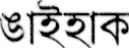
ঙাইহাক
